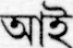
আই
